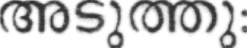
അടുത്തു:
